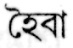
হৈবা
